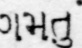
ગમતું
